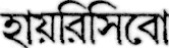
হায়রিসিবো
